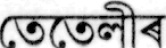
তেতেলীৰ
